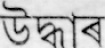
উদ্ধাৰ
